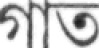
গাত
